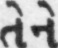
તેને
